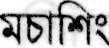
মচাশিং
